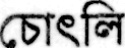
চোৎলি
